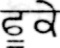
ਫੂਕੇ
